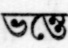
ভন্তে
